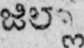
ಜಿಲ್ಲಾ
